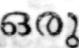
ഒരു
